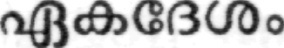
ഏകദേശം
